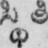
ಸ್ಥಿತಿ
